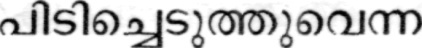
പിടിച്ചെടുത്തുവെന്ന
